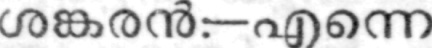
ശങ്കരന്‍:-എന്നെ
